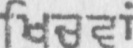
ਖਿਚਵਾਂ
